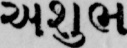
અશુભ
